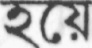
হয়ে
